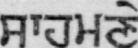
ਸਾਹਮਣੇ
